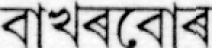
বাখৰবোৰ
